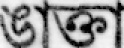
ঙাক্তা
